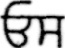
ਓਸ
